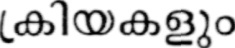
ക്രിയകളും
